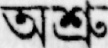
অশ্রু
